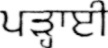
ਪੜ੍ਹਾਈ
